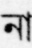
না
